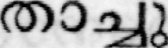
താച്ചു
